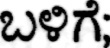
ಬಳಿಗೆ;
